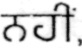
ਨਹੀਂ,
